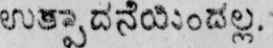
ಉತ್ಪಾದನೆಯಿಂದಲ್ಲ.
